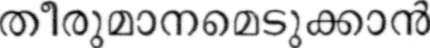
തീരുമാനമെടുക്കാന്‍
